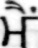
ਮੈਂ
